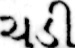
ચડી
